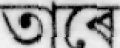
তাৰে
